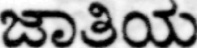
ಜಾತಿಯ
